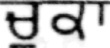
ਚੁਕਾ
